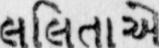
લલિતાએ
